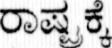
ರಾಷ್ಟ್ರಕ್ಕೆ
